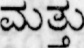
ಮತ್ತು
